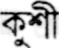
কুশী
